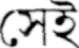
সেই
